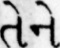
તેને
